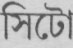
সিটো
